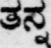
ತನ್ನ
